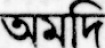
অমদি
